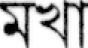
মখা
